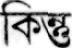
কিন্তু
